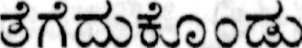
ತೆಗೆದುಕೊಂಡು
